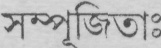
সম্পূজিতাঃ
